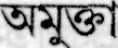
অমুক্তা
